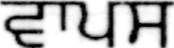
ਵਾਪਸ
